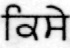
ਕਿਸੇ
